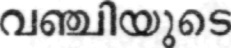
വഞ്ചിയുടെ
